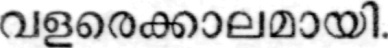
വളരെക്കാലമായി.
